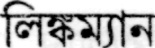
লিঙ্কম্যান
